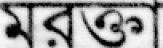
মরক্তা
